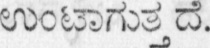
ಉಂಟಾಗುತ್ತದೆ.
